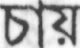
চায়
